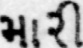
મારી
